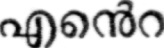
എന്റെ
